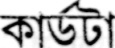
কার্ডটা
